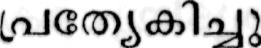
പ്രത്യേകിച്ചു
